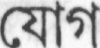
যোগ
